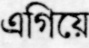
এগিয়ে
